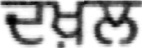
ਦਖ਼ਲ
